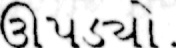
ઊપડ્યો.
